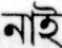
নাই
